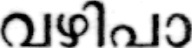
വഴിപാ
